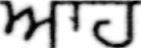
ਆਹ
